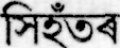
সিহঁতৰ
